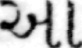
આ
